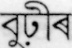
বুঢ়ীৰ
